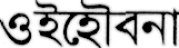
ওইহৌবনা
